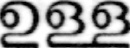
ഉള്ള
